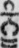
ਨੂੰ
